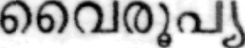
വൈരൂപ്യ
